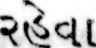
રહેવા
